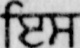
ਇਸ
